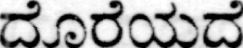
ದೊರೆಯದೆ
